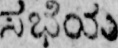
ಸಭೆಯ
